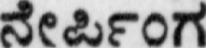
ನೇರ್ಪಿಂಗ
